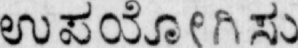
ಉಪಯೋಗಿಸು
